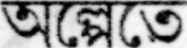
অল্পেতে
